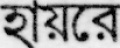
হায়রে
